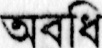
অবধি
